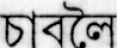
চাবলৈ
